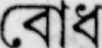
বোধ
